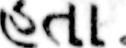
હતા.
